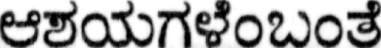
ಆಶಯಗಳೆಂಬಂತೆ
